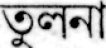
তুলনা
